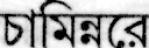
চামিন্নরে
